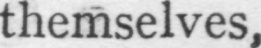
themselves,
